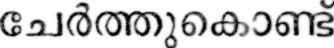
ചേര്‍ത്തുകൊണ്ട്
